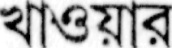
খাওয়ার
